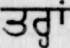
ਤਰ੍ਹਾਂ
